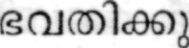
ഭവതിക്കു
